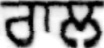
ਰਾਲ
